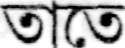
তাতে
